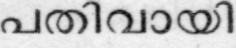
പതിവായി
